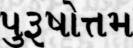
પુરૂષોત્તમ
